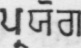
ਪ੍ਰਯੋਗ
